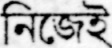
নিজেই
